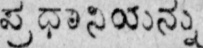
ಪ್ರಧಾನಿಯನ್ನು
